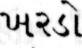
ખરડો
